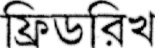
ফ্রিডরিখ
